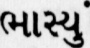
ભાસ્યું
